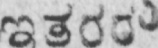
ಇತರರು
